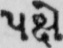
પક્ષે
